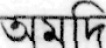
অমদি
